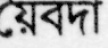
য়ৈবদা
